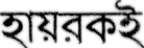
হায়রকই
